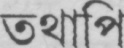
তথাপি
